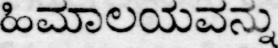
ಹಿಮಾಲಯವನ್ನು
